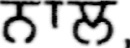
ਨਾਲ,
